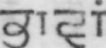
ਭਾਵਾਂ
